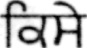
ਕਿਸੇ
